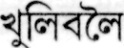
খুলিবলৈ
